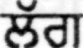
ਲੱਗ
